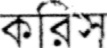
করিস
